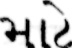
માટે
